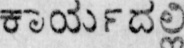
ಕಾರ್ಯದಲ್ಲಿ
